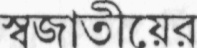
স্বজাতীয়ের
